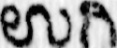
ಉಗಿ
